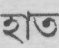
হাত
